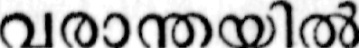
വരാന്തയില്‍
